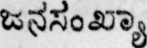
ಜನಸಂಖ್ಯಾ
